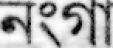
নংগা
